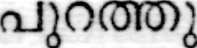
പുറത്തു
